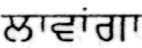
ਲਾਵਾਂਗਾ
